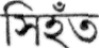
সিহঁত
